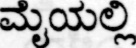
ಮೈಯಲ್ಲಿ
